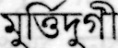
মুর্ত্তিদুগী
